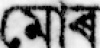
মোৰ
